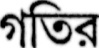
গতির
